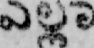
ಎಲ್ಲಾ
